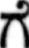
ಗೆ
